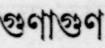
গুণাগুণ
